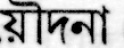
য়ৌদনা
